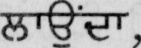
ਲਾਉਂਦਾ,
